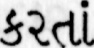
કરતાં
